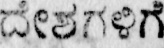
ದೇಶಗಳಿಗೆ
